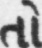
તો
